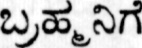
ಬ್ರಹ್ಮನಿಗೆ
